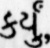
કર્યું,
